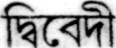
দ্বিবেদী
